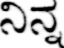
ನಿನ್ನ
